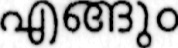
എങ്ങും
